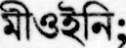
মীওইনি;
